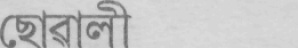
ছোৱালী
